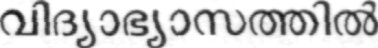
വിദ്യാഭ്യാസത്തില്‍
